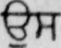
ਉਸ
